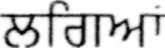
ਲਗਿਆਂ
